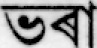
ভৰা
